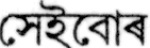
সেইবোৰ
